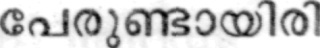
പേരുണ്ടായിരി
